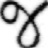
જ
